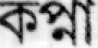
কপ্না
